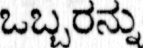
ಒಬ್ಬರನ್ನು
